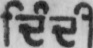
ਦਿੰਦੀ
